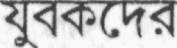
যুবকদের
